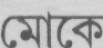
মোকে
